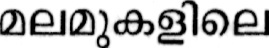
മലമുകളിലെ
